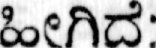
ಹೀಗಿದೆ:
